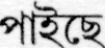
পাইছে
